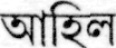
আহিল
